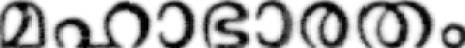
മഹാഭാരതം
